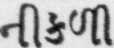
નીકળી
